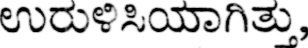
ಉರುಳಿಸಿಯಾಗಿತ್ತು,
